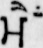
ਮੈਂ
